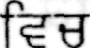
ਵਿਚ
